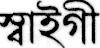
স্বাইগী
